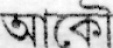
আকৌ
